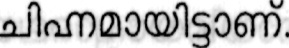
ചിഹ്നമായിട്ടാണ്.
